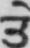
ਤੇ
